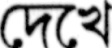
দেখে
